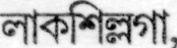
লাকশিল্লগা,
